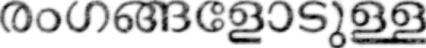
രംഗങ്ങളോടുള്ള
